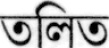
তলিত
